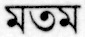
মতম
